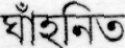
ঘাঁহনিত
